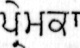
ਪ੍ਰੇਮਕਾ
